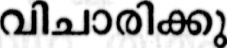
വിചാരിക്കു
